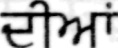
ਦੀਆਂ
